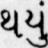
થયું
